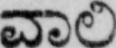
ವಾಲಿ
